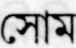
সোম
